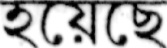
হয়েছে
